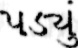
પડ્યું
